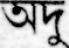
অদু
